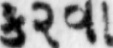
કરવા
